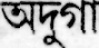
অদুগা
